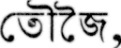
তৌজৈ,
